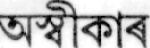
অস্বীকাৰ
